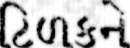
ટિળકને
